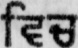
ਵਿਚ
